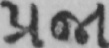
પ્રજા
